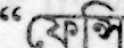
“ফেন্সি
